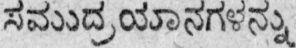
ಸಮುದ್ರಯಾನಗಳನ್ನು
